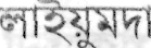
লাইয়ুমদা
